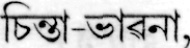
চিন্তা-ভাৱনা,
